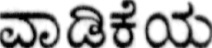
ವಾಡಿಕೆಯ
